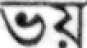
ভয়
